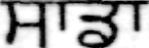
ਸਾਡਾ
